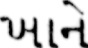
ખાને
